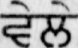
ਵੇਲੇ
